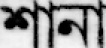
শানা
